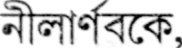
নীলার্ণবকে,
